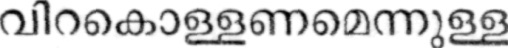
വിറകൊള്ളണമെന്നുള്ള
